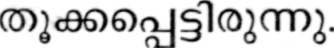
തൂക്കപ്പെട്ടിരുന്നു.
